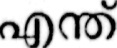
എന്ത്
